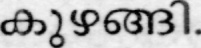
കുഴങ്ങി.
